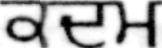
ਕਦਮ
